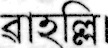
ৱাহল্লি।
